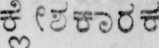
ಕ್ಲೇಶಕಾರಕ
